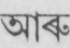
আৰু
